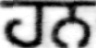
ਹਨ
